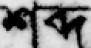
শব্দ
